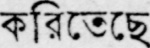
করিতেছে
